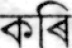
কৰি
